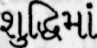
શુદ્ધિમાં
